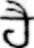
ਹੈ
